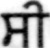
ਸੀ
